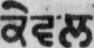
ਕੇਵਲ
